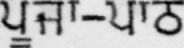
ਪੂਜਾ-ਪਾਠ
